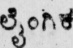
ಲೈಂಗಿಕ
